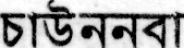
চাউননবা
